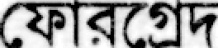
ফোরগ্রেদ
